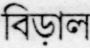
বিড়াল
